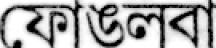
ফোঙলবা
